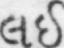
લઈ
